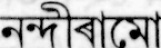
নন্দীৰামো
